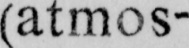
(atmos-
